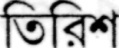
তিরিশ
